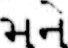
મને
